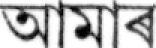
আমাৰ
